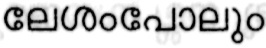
ലേശംപോലും
